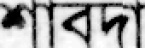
শাবদা
